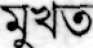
মুখত
